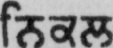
ਨਿਕਲ
